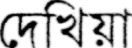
দেখিয়া
